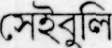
সেইবুলি
